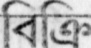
বিক্রি
